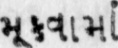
મૂકવામાં
